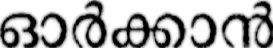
ഓര്‍ക്കാന്‍
